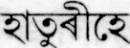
হাতুৰীহে
